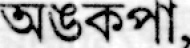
অঙকপা,
